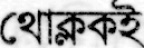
থোক্লকই
